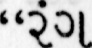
"રંગ
